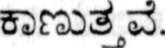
ಕಾಣುತ್ತವೆ.
